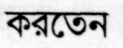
করতেন
